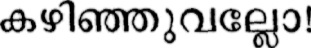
കഴിഞ്ഞുവല്ലോ!
